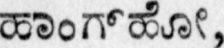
ಹಾಂಗ್‌ಹೋ,
